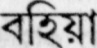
বহিয়া
